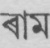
ৰাম
